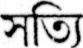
সত্যি
